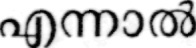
എന്നാല്‍
